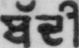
ਬੱਦੀ
